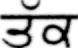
ਤੱਕ
